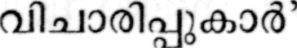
വിചാരിപ്പുകാര്‍'
